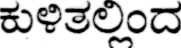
ಕುಳಿತಲ್ಲಿಂದ
